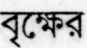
বৃক্ষের
